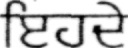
ਇਹਦੇ
